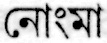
নোংমা
